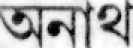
অনাথ
